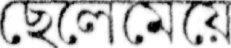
ছেলে;
